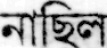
নাছিল
